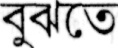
বুঝতে
